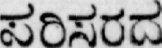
ಪರಿಸರದ
